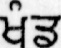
ਖੰਡ
